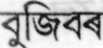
বুজিবৰ
